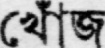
খোঁজ
